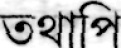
তথাপি
